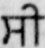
ਸੀ
